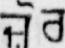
ਜ਼ੋਰ
